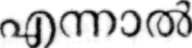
എന്നാല്‍
